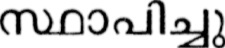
സ്ഥാപിച്ചു
